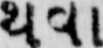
થવા
